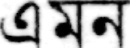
এমন
